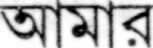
আমার
